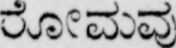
ರೋಮವು
